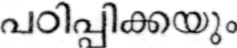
പഠിപ്പിക്കയും
